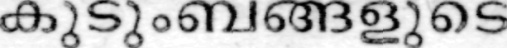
കുടുംബങ്ങളുടെ
